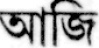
আজি
